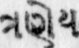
ત્રણેય
